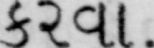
કરવા.
